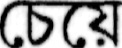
চেয়ে
